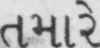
તમારે
